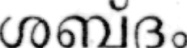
ശബ്ദം
